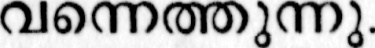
വന്നെത്തുന്നു.
